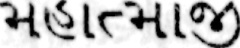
મહાત્માજી
